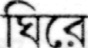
ঘিরে
